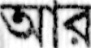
আর
